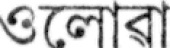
ওলোৱা
